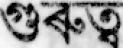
গুৰুত্ব
